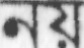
নয়
